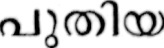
പുതിയ
